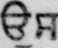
ਉਸ
